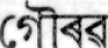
গৌৰৱ
